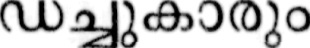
ഡച്ചുകാരും
